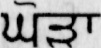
ਘੋੜਾ
